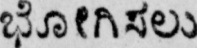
ಭೋಗಿಸಲು
